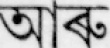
আৰু
